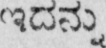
ಇದನ್ನು
